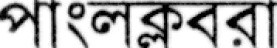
পাংলক্লবরা
